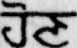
ਹੋਣ
